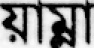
য়াম্না
